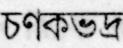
চণকভদ্র
